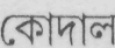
কোদাল
